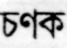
চণক
